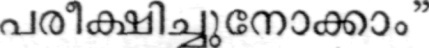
പരീക്ഷിച്ചുനോക്കാം”
